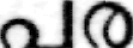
പര
